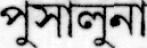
পুসালুনা
